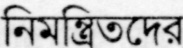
নিমন্ত্রিতদের
